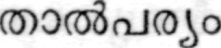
താല്‍പര്യം
